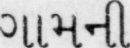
ગામની
